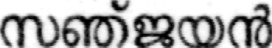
സഞ്ജയന്‍
